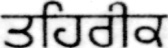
ਤਹਿਰੀਕ
